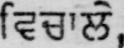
ਵਿਚਾਲੇ,
